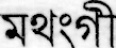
মথংগী
